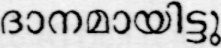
ദാനമായിട്ടു
